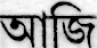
আজি
